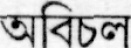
অবিচল
